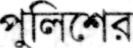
পুলিশের
